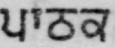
ਪਾਠਕ
